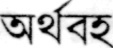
অর্থবহ
